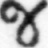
જ
